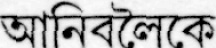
আনিবলৈকে
